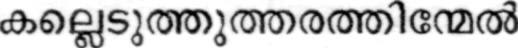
കല്ലെടുത്തുത്തരത്തിന്മേല്‍
